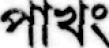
পাখং
